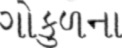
ગોકુળના
